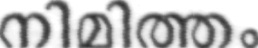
നിമിത്തം
